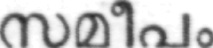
സമീപം
